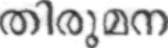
തിരുമന
